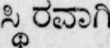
ಸ್ಥಿರವಾಗಿ
